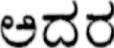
ಅದರ
